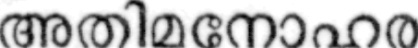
അതിമനോഹര
